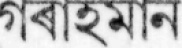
গৰাহমান
